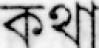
কথা
